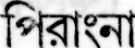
পিরাংনা
